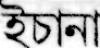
ইচানা
